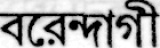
বরেন্দাগী
